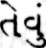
તેવું
